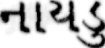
નાયડુ
